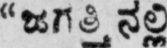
“ಜಗತ್ತಿನಲ್ಲಿ
